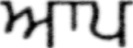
ਆਪ
